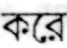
করে
